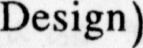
Design)
